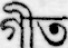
গীত
